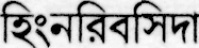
হিংনরিবসিদা
